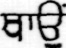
ਥਾਉਂ
